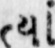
ત્યાં
